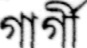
গার্গী
